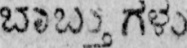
ಬಾಬ್ತುಗಳು
